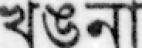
খঙনা
